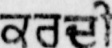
ਕਰਦੀ
